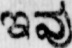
ಇವು
